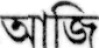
আজি
